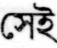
সেই
